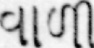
વાળી
